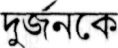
দুর্জনকে
